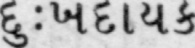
દુઃખદાયક
